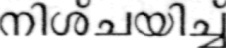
നിശ്ചയിച്ച്
